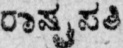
ರಾಷ್ಟ್ರಪತಿ
